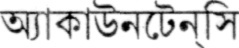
অ্যাকাউনটেন্সি
